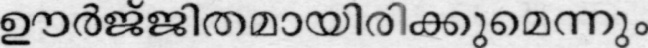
ഊര്‍ജ്ജിതമായിരിക്കുമെന്നും
